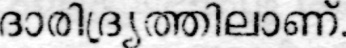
ദാരിദ്ര്യത്തിലാണ്.
